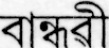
বান্ধৱী
